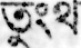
তুংথ
